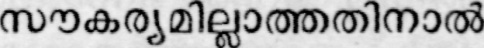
സൌകര്യമില്ലാത്തതിനാല്‍
